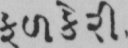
ફળકેરી.
